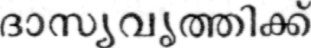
ദാസ്യവൃത്തിക്ക്
